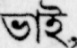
ভাই,
